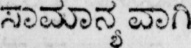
ಸಾಮಾನ್ಯವಾಗಿ
